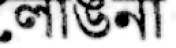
লোঙনা
